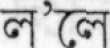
ল'লে
